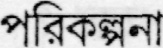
পরিকল্পনা
